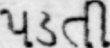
લાગણી
